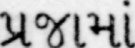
પ્રજામાં
